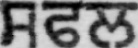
ਸਫਲ
